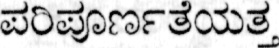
ಪರಿಪೂರ್ಣತೆಯತ್ತ
